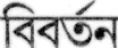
বিবর্তন
